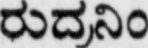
ರುದ್ರನಿಂ
